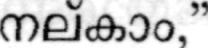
നല്‌കാം,”
